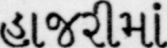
હાજરીમાં
